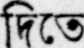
দিতে
